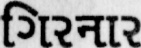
ગિરનાર
